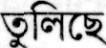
তুলিছে
